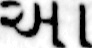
આ
